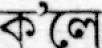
ক'লে
